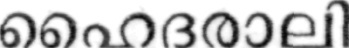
ഹൈദരാലി
